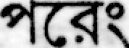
পরেং
